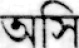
অসি
